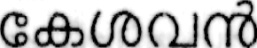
കേശവന്‍
